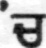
'ਚ
